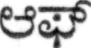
ಆಫ್
